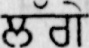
ਲੱਗੇ
